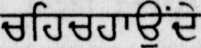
ਚਹਿਚਹਾਉਂਦੇ
